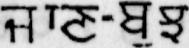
ਜਾਣ-ਬੁਝ
